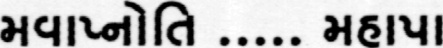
મવાપ્નોતિ.....મહાપા
